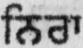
ਨਿਰਾ
